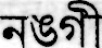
নঙগী
